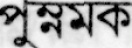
পুম্নমক
